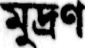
মুদ্রণ
